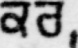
ਕਰ,
